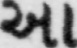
આ
